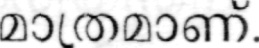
മാത്രമാണ്.
